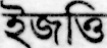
ইজত্তি
